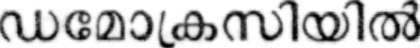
ഡമോക്രസിയില്‍
